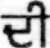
ਦੀ
